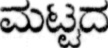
ಮಟ್ಟದ
